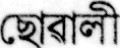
ছোৱালী
